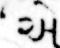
'એ
